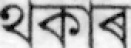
থকাৰ
